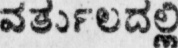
ವರ್ತುಲದಲ್ಲಿ
